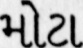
મોટા
